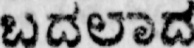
ಬದಲಾದ
